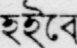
হইবে
